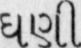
ઘણી
